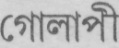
গোলাপী
